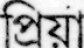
প্রিয়া
